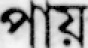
পায়
